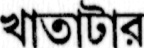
খাতাটার
